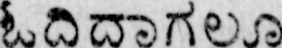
ಓದಿದಾಗಲೂ
